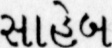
સાહેબ
